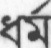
ধর্ম
